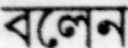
বলেন
